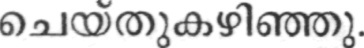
ചെയ്തുകഴിഞ്ഞു.
